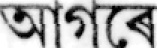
আগৰে
